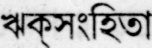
ঋক্সংহিতা
